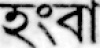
হংবা
